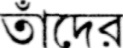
তাঁদের
